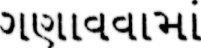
ગણાવવામાં
